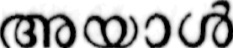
അയാള്‍
